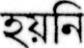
হয়নি
